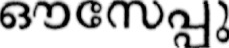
ഔസേപ്പു
